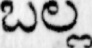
ಬಲ್ಲ
